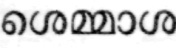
ശെമ്മാശ
